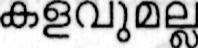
കളവുമല്ല
